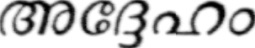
അദ്ദേഹം
